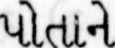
પોતાને
